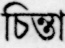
চিন্তা
